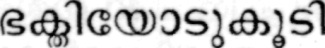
ഭക്തിയോടുകൂടി
